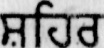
ਸ਼ਹਿਰ
